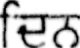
ਦਿਨ
